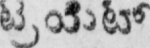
ಟ್ರಯೆಟ್
